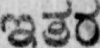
ಇತರ
